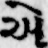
એ
